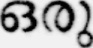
ഒരു
